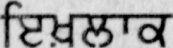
ਇਖ਼ਲਾਕ
